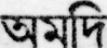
অমদি
